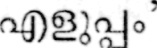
എളുപ്പം'
